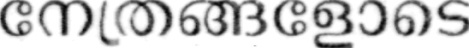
നേത്രങ്ങളോടെ
